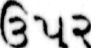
ઉપર
